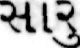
સારુ
